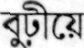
বুঢ়ীয়ে
